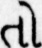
તો
